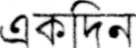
একদিন
